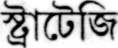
স্ট্রাটেজি
